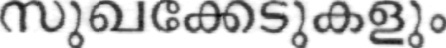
സുഖക്കേടുകളും
